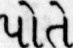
પોતે
